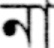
না
